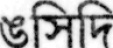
ঙসিদি
